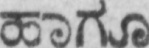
ಹಾಗೂ
